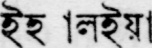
ইহালইয়া
